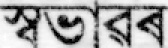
স্বভাৱৰ
